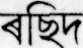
ৰছিদ
